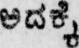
ಅದಕ್ಕೆ
